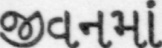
જીવનમાં
